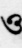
ও
